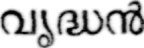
വൃദ്ധന്‍
